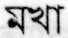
মখা
